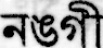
নঙগী
